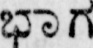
ಭಾಗ
